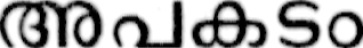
അപകടം
